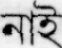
নাই
